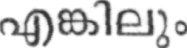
എങ്കിലും
